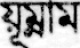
য়ূম্নাম
